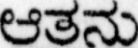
ಆತನು
